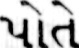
પોતે
